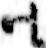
ન
